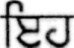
ਇਹ
